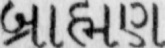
બ્રાહ્મણ
